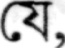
যে,
